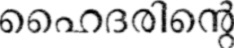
ഹൈദരിന്റെ
